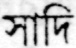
সাদি
